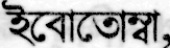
ইবোতোম্বা,
